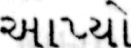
આપ્યો
